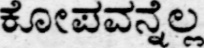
ಕೋಪವನ್ನೆಲ್ಲ
